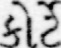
કોર્ટે
